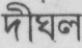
দীঘল
